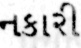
નકારી
